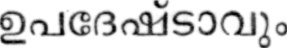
ഉപദേഷ്ടാവും
